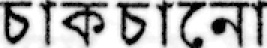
চাকচানো
